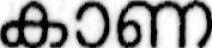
കാണ
